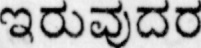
ಇರುವುದರ
